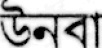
উনবা
